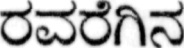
ರವರೆಗಿನ
